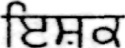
ਇਸ਼ਕ
